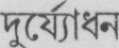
দুৰ্য্যোধন
